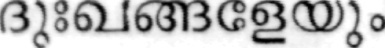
ദുഃഖങ്ങളേയും
